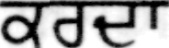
ਕਰਦਾ
